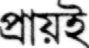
প্রায়ই
